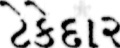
ટેકેદાર
